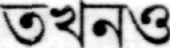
তখনও
